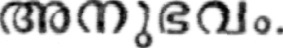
അനുഭവം.
